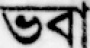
ভবা
